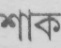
শাক
